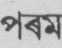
পৰম
